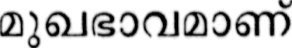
മുഖഭാവമാണ്
